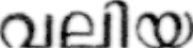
വലിയ
